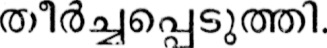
തീര്‍ച്ചപ്പെടുത്തി.
